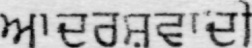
ਆਦਰਸ਼ਵਾਦੀ
